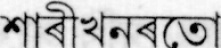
শাৰীখনৰতো
